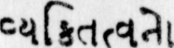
વ્યક્તિત્વનો
